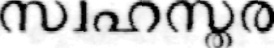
സ്വഹസ്തര
